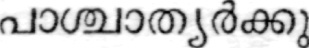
പാശ്ചാത്യര്‍ക്കു
